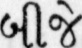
બીજે
